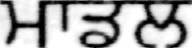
ਮਾਡਲ
